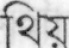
থিয়
